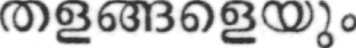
തളങ്ങളെയും
